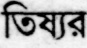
তিষ্যর
